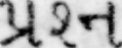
પ્રશ્ન
